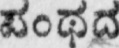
ಪಂಥದ
